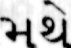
મથે
